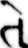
તે
